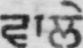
ਵਾਲੇ
